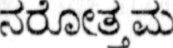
ನರೋತ್ತಮ
